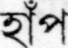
হাঁপ
